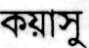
কয়াসু
